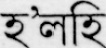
হ'লহি
